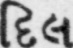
દિલ
